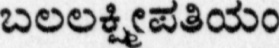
ಬಲಲಕ್ಷ್ಮೀಪತಿಯಂ
